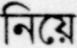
নিয়ে
